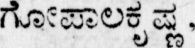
ಗೋಪಾಲಕೃಷ್ಣ,
